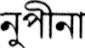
নুপীনা
